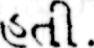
હતી.
